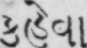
કહેવા
